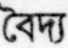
বৈদ্য
